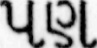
પણ
